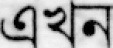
এখন
